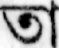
তা
